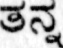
ತನ್ನ
